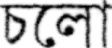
চলো
